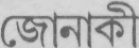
জোনাকী
